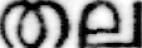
തല
